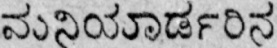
ಮನಿಯಾರ್ಡರಿನ
